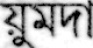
য়ুমদা
